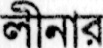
লীনার
